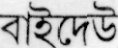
বাইদেউ
